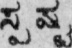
ಸ್ಪಷ್ಟ
